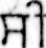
ਸੀ
